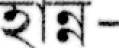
হান্ন-
